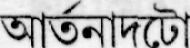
আর্তনাদটো
